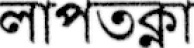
লাপতক্না
